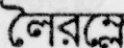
লৈরম্লে
